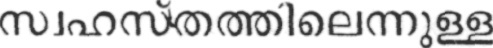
സ്വഹസ്തത്തിലെന്നുള്ള
